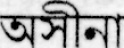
অসীনা
